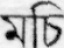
মচি
